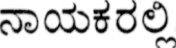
ನಾಯಕರಲ್ಲಿ
